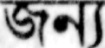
জন্য
